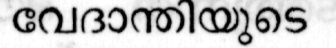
വേദാന്തിയുടെ
